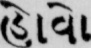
હોવો
